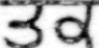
ਤਕ
